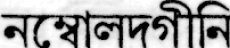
নম্বোলদগীনি
